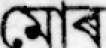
মোৰ
